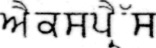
ਐਕਸਪ੍ਰੈੱਸ
